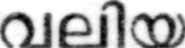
വലിയ
